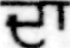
ਦਾ
